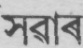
সৱাৰ
